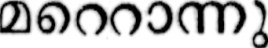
മറെറാന്നു
